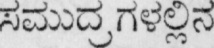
ಸಮುದ್ರಗಳಲ್ಲಿನ
